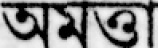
অমত্তা
